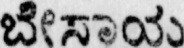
ಬೇಸಾಯ
